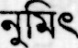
নুমিৎ
